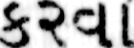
કરવા
